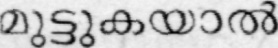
മുട്ടുകയാല്‍
